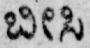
ಬೀಸಿ
